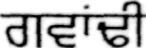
ਗਵਾਂਢੀ
